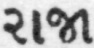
રાજા
